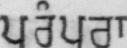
ਪਰੰਪਰਾ
